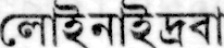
লোইনাইদ্রবা
